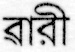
ৱারী
